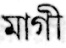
মাগী
